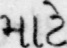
માટે
